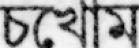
চাখোম
